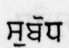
ਸੁਬੋਧ
